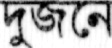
দুজনে
